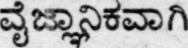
ವೈಜ್ಞಾನಿಕವಾಗಿ
